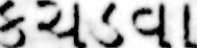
કચડવા
